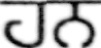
ਹਨ
